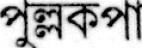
পুল্লকপা
